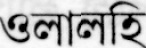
ওলালহি
